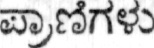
ಪ್ರಾಣಿಗಳು
